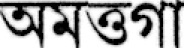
অমত্তগা
